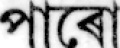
পাৰো
